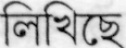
লিখিছে
